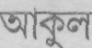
আকুল
